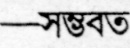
–সম্ভবত
